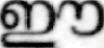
ഈ
